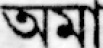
অমা
